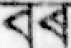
বৰ
